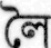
লৈ
